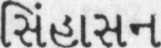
સિંહાસન
